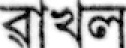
ৱাখল
